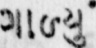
ગાળ્યું
